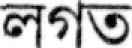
লগত
